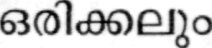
ഒരിക്കലും
